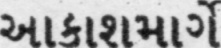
આકાશમાર્ગે
